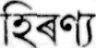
হিৰণ্য
